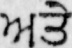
ਅਤੇ
